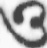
ও
